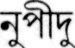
নুপীদু
